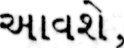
આવશે,
